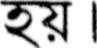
হয়।
